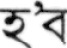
হ'ব
